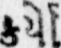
કર્યો
